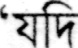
‘যদি
